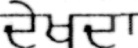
ਦੇਖਦਾ
